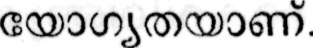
യോഗ്യതയാണ്.
